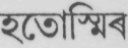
হতোস্মিৰ
